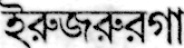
ইরুজরুরগা
